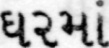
ઘરમાં
